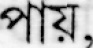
পায়,
